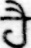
ਹੈ
